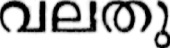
വലതു
